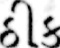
ઠીક
